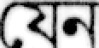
যেন
